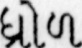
ધ્રોળ
